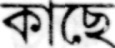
কাছে
